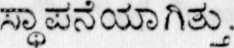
ಸ್ಥಾಪನೆಯಾಗಿತ್ತು.
